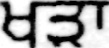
ਖੜਾ
